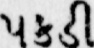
પકડી
